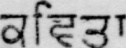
ਕਵਿਤਾ
